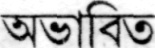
অভাবিত
